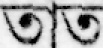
তাত
